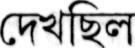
দেখছিল
